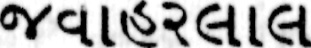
જવાહરલાલ
